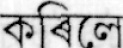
কৰিলে
